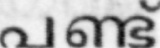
പണ്ട്
